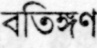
বতিঙ্গণ
